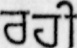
ਰਹੀ
